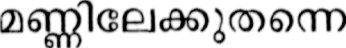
മണ്ണിലേക്കുതന്നെ
